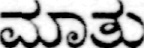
ಮಾತು
